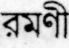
রমণী
